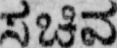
ಸಚಿವ
